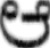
ಆ
